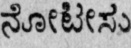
ನೋಟೀಸು
